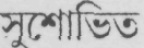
সুশোভিত
